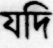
যদি
